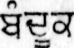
ਬੰਦੂਕ
